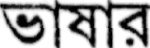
ভাষার
